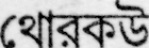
থোরকউ
